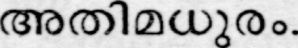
അതിമധുരം.
